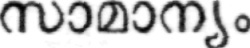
സാമാന്യം
